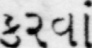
કરવાં
